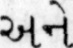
અને
